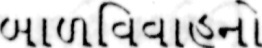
બાળવિવાહનો
